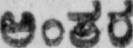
ಅಂತರ
